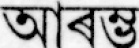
আৰম্ভ
